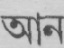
আন
